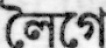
লৈগে
